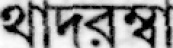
থাদরম্বা
